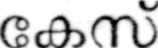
കേസ്
